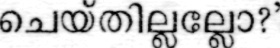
ചെയ്തില്ലല്ലോ?’
